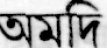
অমদি
